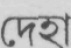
দেহা
